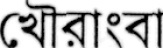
খৌরাংবা
